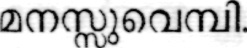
മനസ്സുവെമ്പി.
